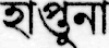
হাপ্তুনা
